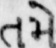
તમે
